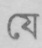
যে
